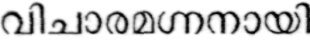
വിചാരമഗ്നനായി
